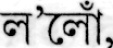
ল'লোঁ,
